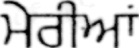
ਮੇਰੀਆਂ
